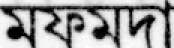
মফমদা
